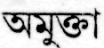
অমুক্তা
